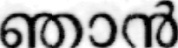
ഞാന്‍
